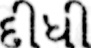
દીધી
